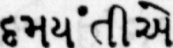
દમયંતીએ
